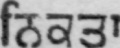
ਨਿਕਤਾ
